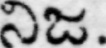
ನಿಜ.
